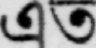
এত
